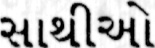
સાથીઓ
